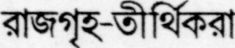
রাজগৃহ-তীর্থিকরা
